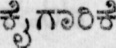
ಕೈಗಾರಿಕೆ
